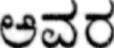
ಅವರ
